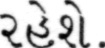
રહેશે.
